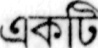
একটি
